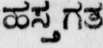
ಹಸ್ತಗತ
